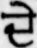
ਦੇ
